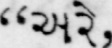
"અરે,
